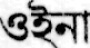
ওইনা
